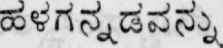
ಹಳಗನ್ನಡವನ್ನು
